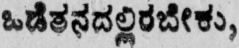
ಒಡೆತನದಲ್ಲಿರಬೇಕು,
